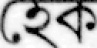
হেক
